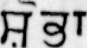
ਸ਼ੋਭਾ
